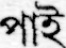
পাই
